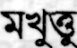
মখুত্তু
